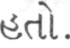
હતો.
